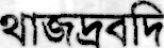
থাজদ্রবদি
